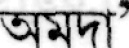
অমদা’
